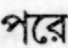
পরে
